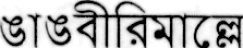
ঙাঙবীরিমাল্লে
